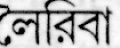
লৈরিবা
